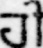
ਹੀ
